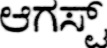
ಆಗಸ್ಟ್
